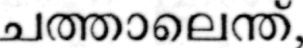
ചത്താലെന്ത്,
